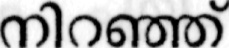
നിറഞ്ഞ്
